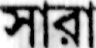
সারা
